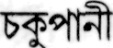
চকুপানী
